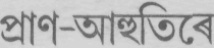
প্ৰাণ-আহুতিৰে
